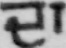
ਦਾ
